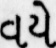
વયે
